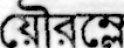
য়ৌরম্লে
